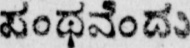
ಪಂಥವೆಂದು
